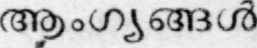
ആംഗ്യങ്ങള്‍
